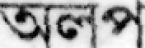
অলপ
